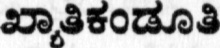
ಖ್ಯಾತಿಕಂಡೂತಿ
